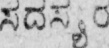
ಸದಸ್ಯರ
